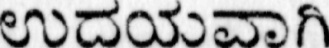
ಉದಯವಾಗಿ
